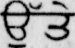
ਉੱਤੇ
